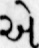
એ
